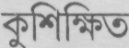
কুশিক্ষিত
